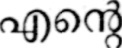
എന്റെ
